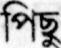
পিছু
